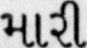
મારી
